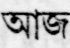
আজ
